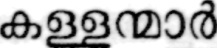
കള്ളന്മാര്‍
